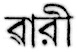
ৱারী
